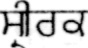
ਸ੍ਰੀਰਕ
